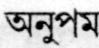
অনুপম
